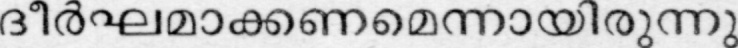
ദീര്‍ഘമാക്കണമെന്നായിരുന്നു
